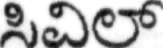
ಸಿವಿಲ್
